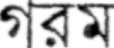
গরম
